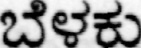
ಬೆಳಕು
